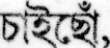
চাইছোঁ,
